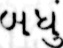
બધું
